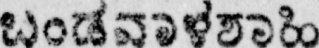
ಬಂಡವಾಳಶಾಹಿ
